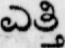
ಎತ್ತಿ
